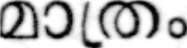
മാത്രം
